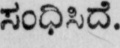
ಸಂಧಿಸಿದೆ.
